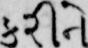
કરીને
